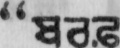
''ਬਰਫ਼
